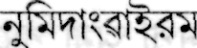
নুমিদাংৱাইরম
